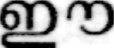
ഈ
